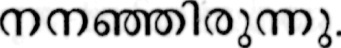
നനഞ്ഞിരുന്നു.
